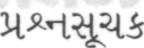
પ્રશ્નસૂચક
